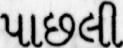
પાછલી
